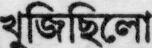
খুজিছিলো
